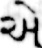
એ
